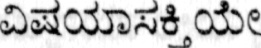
ವಿಷಯಾಸಕ್ತಿಯೇ
